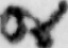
જ
